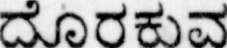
ದೊರಕುವ
